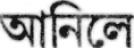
আনিলে
